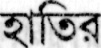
হাতির
